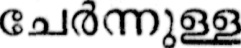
ചേര്‍ന്നുള്ള
